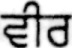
ਵੀਰ
